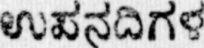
ಉಪನದಿಗಳ
